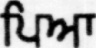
ਪਿਆ
